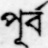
পূর্ব
